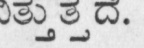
ಬಿತ್ತುತ್ತದೆ.
